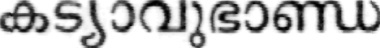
കട്യാവുഭാണ്ഡ
